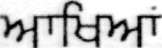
ਆਖਿਆਂ
